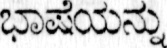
ಭಾಷೆಯನ್ನು
